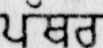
ਪੱਥਰ
